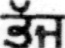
ਭੱਜ
